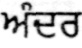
ਅੰਦਰ
